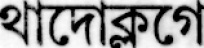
থাদোক্লগে
